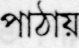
পাঠায়
